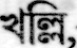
খল্লি,
